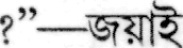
?"-জয়াই
